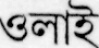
ওলাই
